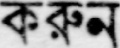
করুন
